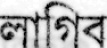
লাগিব
